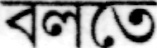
বলতে
